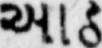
આઠ
